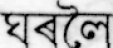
ঘৰলৈ
